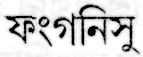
ফংগনিসু
